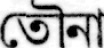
তৌনা
